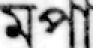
মপা
